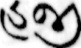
હજી
